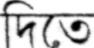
দিতে
